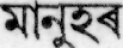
মানুহৰ
